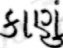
કાણું
